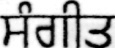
ਸੰਗੀਤ
